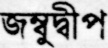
জম্বুদ্বীপ
